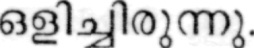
ഒളിച്ചിരുന്നു.
